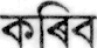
কৰিব
